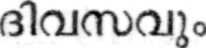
ദിവസവും
